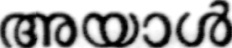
അയാള്‍
